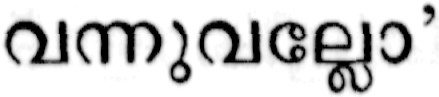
വന്നുവല്ലോ’
